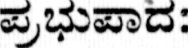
ಪ್ರಭುಪಾದ:
